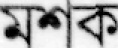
মশক
